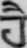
ਹੈ
